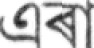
এৰা
